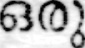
ഒരു
